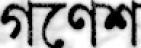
গণেশ
